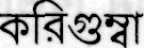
করিগুম্বা
